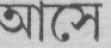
আসে
